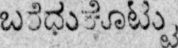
ಬರೆಧುಕೊಟ್ಟು
